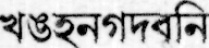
খঙহনগদবনি
